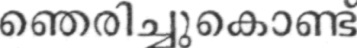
ഞെരിച്ചുകൊണ്ട്
